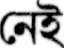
নেই
